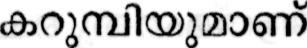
കറുമ്പിയുമാണ്
